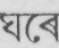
ঘৰে
